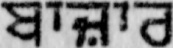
ਬਾਜ਼ਾਰ
